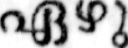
ഏഴു
